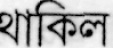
থাকিল
